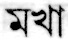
মখা
